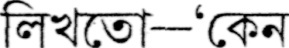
লিখতো–‘কেন
